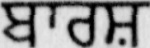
ਬਾਰਸ਼
